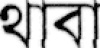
থাবা
